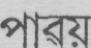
পাৱয়
